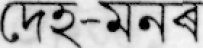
দেহ-মনৰ
